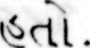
હતો.
